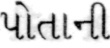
પોતાની
